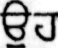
ਉਹ
